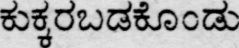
ಕುಕ್ಕರಬಡಕೊಂಡು
